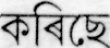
কৰিছে
